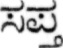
ಸಪ್ತ
